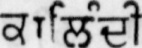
ਕਾਲਿੰਦੀ
